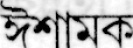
ঈশামক
